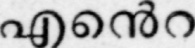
എന്റെ
